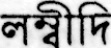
লম্বীদি
